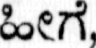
ಹೀಗೆ,
